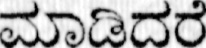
ಮಾಡಿದರೆ
